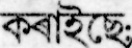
কৰাইছে;
